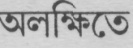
অলক্ষিতে
